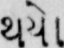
થયો
